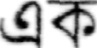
এক
